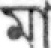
মা
